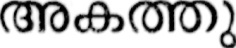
അകത്തു
